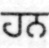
ਹਨ
